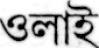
ওলাই
